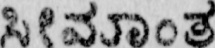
ಸೀಮಾಂತ
